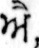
ਐ,
